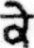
ਕੇ
